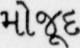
મોજૂદ
